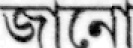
জানো
